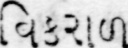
વિકરાળ
